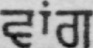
ਵਾਂਗ
